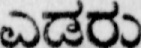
ಎರಡು
